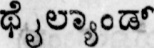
ಥೈಲ್ಯಾಂಡ್
